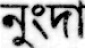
নুংদা
